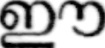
ഈ
